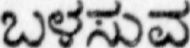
ಬಳಸುವ
